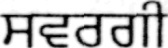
ਸਵਰਗੀ
